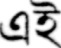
এই
